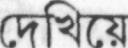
দেখিয়ে
